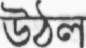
উঠল
